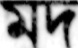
মদ
